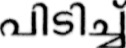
പിടിച്ച്
